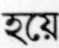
হয়ে
